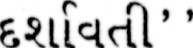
દર્શાવતી"
